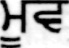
ਮੂਵ
